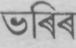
ভৰিৰ
